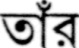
তাঁর
